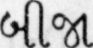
બીજા
